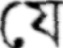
যে
